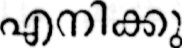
എനിക്കു
